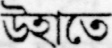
উহাতে
